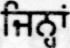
ਜਿਨ੍ਹਾਂ
